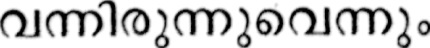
വന്നിരുന്നുവെന്നും
